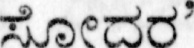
ಸೋದರ’
